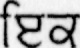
ਇਕ
